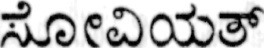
ಸೋವಿಯತ್
